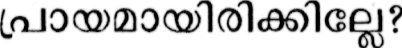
പ്രായമായിരിക്കില്ലേ?
